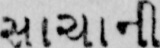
સાચાની
